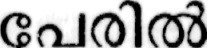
പേരില്‍
